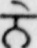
ਨੇ
